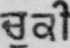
ਚੁਕੀ
